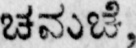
ಚಮಚೆ,
